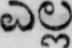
ಎಲ್ಲ
